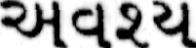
અવશ્ય
